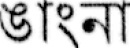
ঙাংনা
